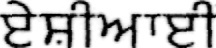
ਏਸ਼ੀਆਈ
